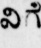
ವಿಗೆ
